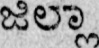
ಜಿಲ್ಲಾ
